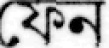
ফেন
